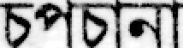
চপচানা
